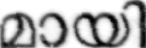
മായി
